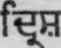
ਦ੍ਰਿਸ਼
